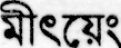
মীৎয়েং
